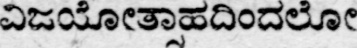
ವಿಜಯೋತ್ಸಾಹದಿ೦ದಲೋ
